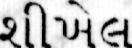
શીખેલ
